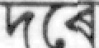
দৰে
